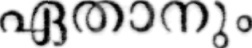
ഏതാനും
